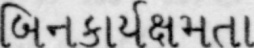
બિનકાર્યક્ષમતા
